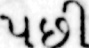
પછી
